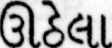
ઊઠેલા
